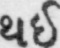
થઈ
